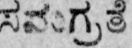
ಸಮಗ್ರತೆ
